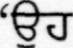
'ਉਹ
